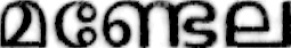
മണ്ടേല
